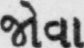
જોવા
